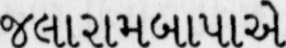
જલારામબાપાએ
